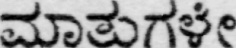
ಮಾತುಗಳೇ
